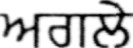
ਅਗਲੇ
